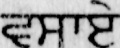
ਵਸਾਏ
